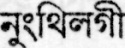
নুংথিলগী
